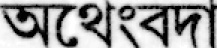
অথেংবদা
